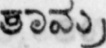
ತಾಮ್ರ
